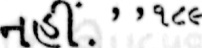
નહીં."૧૮૯
